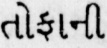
તોફાની
